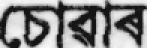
চোৱাৰ
